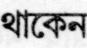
থাকেন
